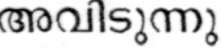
അവിടുന്നു
